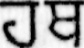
ਹਥ
